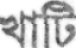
খাটি
